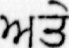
ਅਤੇ
